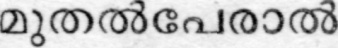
മുതല്‍പേരാല്‍
